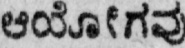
ಆಯೋಗವು
